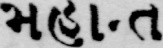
મહાન્ત
